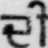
ਦੀ
